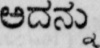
ಅದನ್ನು
